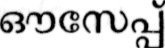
ഔസേപ്പ്
